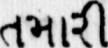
તમારી
